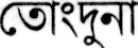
তোংদুনা
